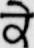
ਕੇ
